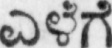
ಎಳೆಗೆ
